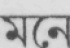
মনে
